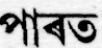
পাৰত
